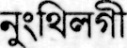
নুংথিলগী
